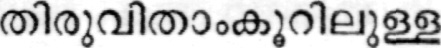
തിരുവിതാംകൂറിലുള്ള
